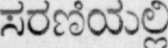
ಸರಣಿಯಲ್ಲಿ
